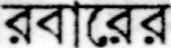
রবারের
